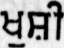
ਖੁਸ਼ੀ
